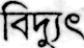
বিদ্যুৎ
